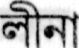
লীনা
